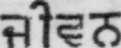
ਜੀਵਨ
